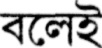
বলেই
